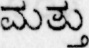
ಮತ್ತು
